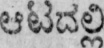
ಆಟದಲ್ಲಿ
